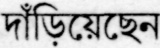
দাঁড়িয়েছেন
